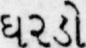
ઘરડો
